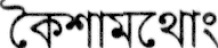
কৈশামথোং
